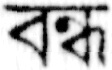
বন্ধ
